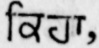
ਕਿਹਾ,
